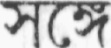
সঙ্গে
